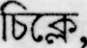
চিক্লে,
